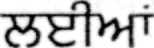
ਲਈਆਂ
